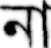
না
